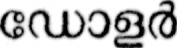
ഡോളര്‍
